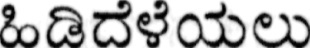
ಹಿಡಿದೆಳೆಯಲು
